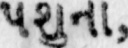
પશુના,
